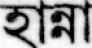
হান্না
